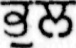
ਭੁਲ
